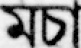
মচা
